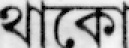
থাকো
